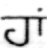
ਹਾਂ
